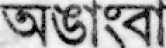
অঙাংবা
